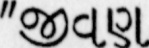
"જીવણ
